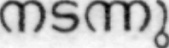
നടന്നു
